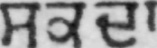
ਸਕਦਾ
